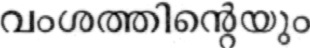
വംശത്തിന്റെയും
